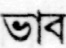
ভাব
